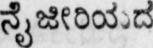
ನೈಜೀರಿಯದ
